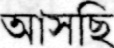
আসছি
